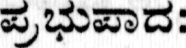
ಪ್ರಭುಪಾದ:
